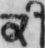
ਕੀ
